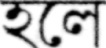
হলে
